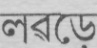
লৱড়ে
